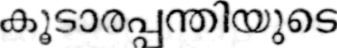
കൂടാരപ്പന്തിയുടെ
